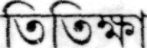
তিতিক্ষা
